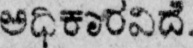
ಅಧಿಕಾರವಿದೆ.
